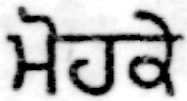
ਮੋਹਕੇ
